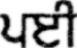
ਪਈ
